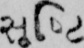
સૃષ્ટિ
